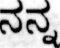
ನನ್ನ
